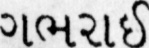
ગભરાઈ
